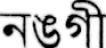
নঙগী
